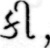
કી,
